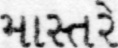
માસ્તરે
